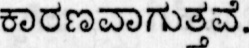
ಕಾರಣವಾಗುತ್ತವೆ.
